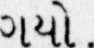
ગયો.
